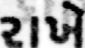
રાખે
